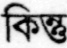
কিন্তু
